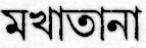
মখাতানা
